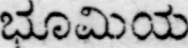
ಭೂಮಿಯ
